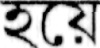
হয়ে
